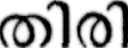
തിരി
